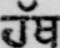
ਹੱਥ
